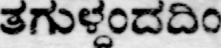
ತಗುಳ್ದಂದದಿಂ
